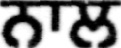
ਨਾਲ
